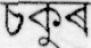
চকুৰ
